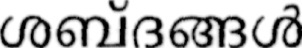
ശബ്ദങ്ങള്‍
